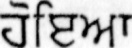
ਹੋਇਆ
